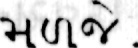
મળજે.
